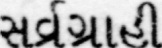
સર્વગ્રાહી
